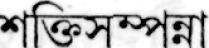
শক্তিসম্পন্না
